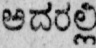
ಅದರಲ್ಲಿ
